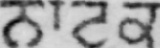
ਨਾਟਕ
